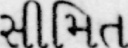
સીમિત
